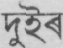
দুইৰ
